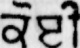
ਕੋਈ
